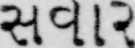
સવાર
